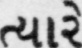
ત્યારે
